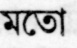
মতো
